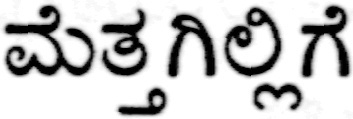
ಮೆತ್ತಗಿಲ್ಲಿಗೆ
